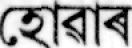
হোৱাৰ
